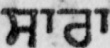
ਸਾਰਾ
